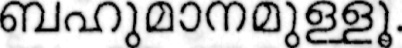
ബഹുമാനമുള്ളൂ.
